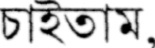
চাইতাম,
